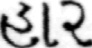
હાર
